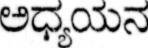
ಅಧ್ಯಯನ
